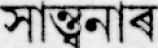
সান্ত্বনাৰ
